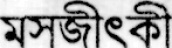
মসজীৎকী
